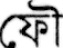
ফৌ
